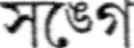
সঙ্গে
